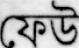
ফেউ
